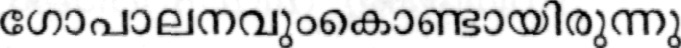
ഗോപാലനവുംകൊണ്ടായിരുന്നു
